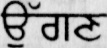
ਉੱਗਣ
